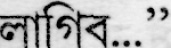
লাগিব..."
